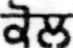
ਕੋਲ
